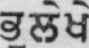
ਭੁਲੇਖੇ
